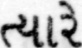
ત્યારે
